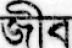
জীব
